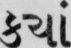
ક્યાં
